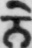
ਨੇ
